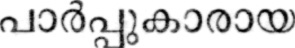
പാര്‍പ്പുകാരായ
